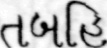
તબહિ
